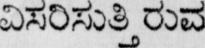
ವಿಸರಿಸುತ್ತಿರುವ
